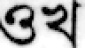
ওখ
